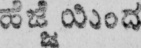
ಹೆಜ್ಜೆಯಿಂದ
